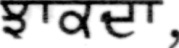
ਝਾਕਦਾ,
